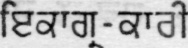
ਇਕਾਗ੍ਰ-ਕਾਰੀ
